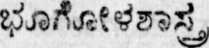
ಭೂಗೋಳಶಾಸ್ತ್ರ
